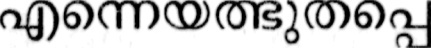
എന്നെയത്ഭുതപ്പെ
